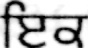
ਇਕ
